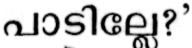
പാടില്ലേ?’
